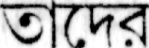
তাদের
